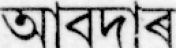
আবদাৰ
